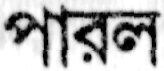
পারল
